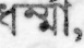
ধর্ম্মা,
